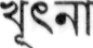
খূৎনা
